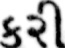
કરી
